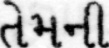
તેમની
